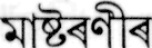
মাষ্টৰণীৰ
